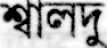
শ্বালদু
